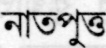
নাতপুত্ত
